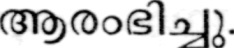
ആരംഭിച്ചു.
